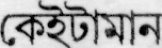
কেইটামান
